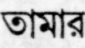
তামার
